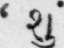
'શું
